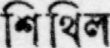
শিথিল
